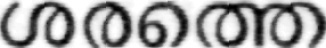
ശരത്തെ
